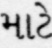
માટે
